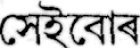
সেইবোৰ
